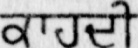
ਕਾਹਦੀ
